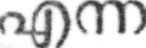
എന്ന
